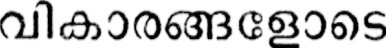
വികാരങ്ങളോടെ
